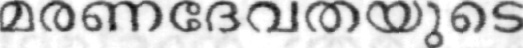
മരണദേവതയുടെ
